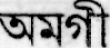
অমগী
